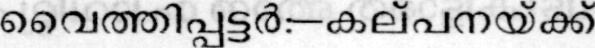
വൈത്തിപ്പട്ടര്‍:-കല്പനയ്ക്ക്
